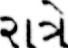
રાત્રે
